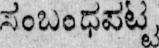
ಸಂಬಂಧಪಟ್ಟ
